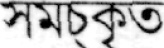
সমচ্‌কৃত
